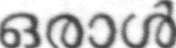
ഒരാള്‍
